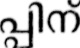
പ്പിന്
